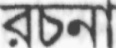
রচনা
